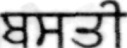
ਬਸਤੀ
